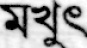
মখুৎ
